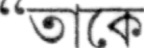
“তাকে
